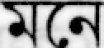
মনে
